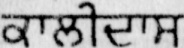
ਕਾਲੀਦਾਸ
